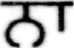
ਨਾ
